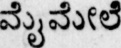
ಮೈಮೇಲೆ
